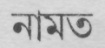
নামত
